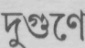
দুগুণে
